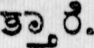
ತ್ತಾರೆ.
